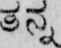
ತನ್ನ
